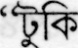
"টুকি
